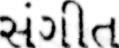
સંગીત
